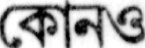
কোনও
